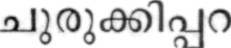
ചുരുക്കിപ്പറ
